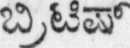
ಬ್ರಿಟಿಷ್
